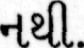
નથી.
